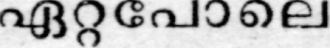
ഏറ്റപോലെ
